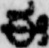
ಈ
